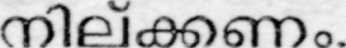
നില്ക്കണം.
